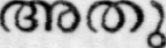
അതു
